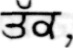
ਤੱਕ,
